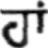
ਹਾਂ
